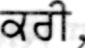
ਕਰੀ,
